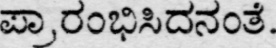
ಪ್ರಾರಂಭಿಸಿದನಂತೆ.
